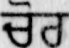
ਚੋਰ
